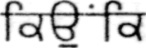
ਕਿਉਂਕਿ
